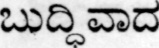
ಬುದ್ಧಿವಾದ
